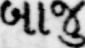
બાજુ
